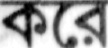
করে
